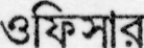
ওফিসার
